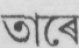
তাৰে
